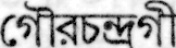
গৌরচন্দ্রগী
